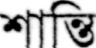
শান্তি
